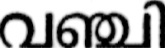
വഞ്ചി
